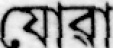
যোৱা
